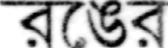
রঙের
